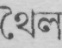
থৈল
